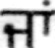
ਜਾਂ
